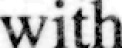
with
